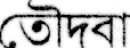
তৌদবা
